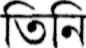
তিনি
